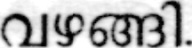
വഴങ്ങി.
